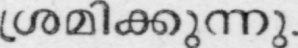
ശ്രമിക്കുന്നു.
